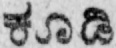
ಕೂಡಿ
